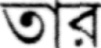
তার
